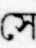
সে
